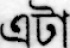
এটা
